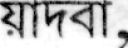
য়াদবা,
